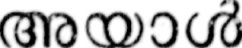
അയാള്‍
